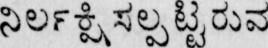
ನಿರ್ಲಕ್ಷಿಸಲ್ಪಟ್ಟಿರುವ
